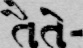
તૈતે-
